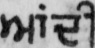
ਆਂਦੀ
